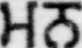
ਮਨ
